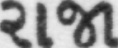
રાજા
